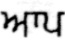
ਆਪ
